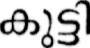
കുട്ടി
